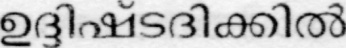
ഉദ്ദിഷ്ടദിക്കില്‍
